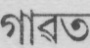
গাৱত
